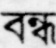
বন্ধ
